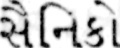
સૈનિકો
